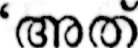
‘അത്
